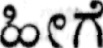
ಹೀಗೆ
